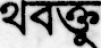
থবক্তু
